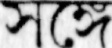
সঙ্গে
